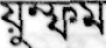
য়ুম্ফম
